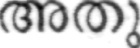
അതു
